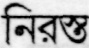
নিরস্ত
